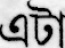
এটা
